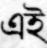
এই
